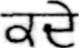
ਕਦੇ
